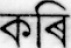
কৰি
